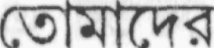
তোমাদের
